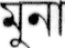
মুনা
